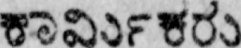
ಕಾರ್ಮಿಕರು
